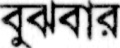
বুঝবার
